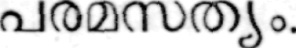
പരമസത്യം.
